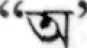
"অ'
